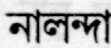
নালন্দা
